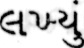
લખ્યું
